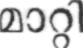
മാറ്റി
